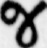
જ
